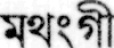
মথংগী
